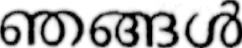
ഞങ്ങള്‍
